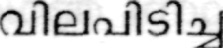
വിലപിടിച്ച
